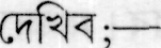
দেখিব;-
